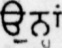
ਉਨ੍ਹਾਂ
